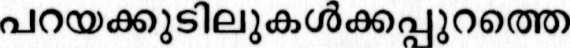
പറയക്കുടിലുകള്‍ക്കപ്പുറത്തെ
